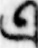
এ
